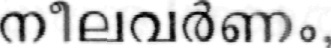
നീലവര്‍ണം,
